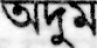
অদুম
